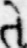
તે
